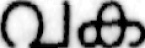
വക
